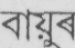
বায়ুৰ
